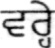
ਵਰ੍ਹੇ
